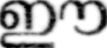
ഈ
